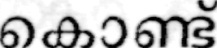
കൊണ്ട്
